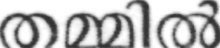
തമ്മില്‍
